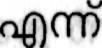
എന്ന്
